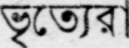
ভৃত্যেরা
